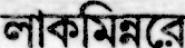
লাকমিন্নরে
